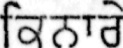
ਕਿਨਾਰੇ
